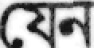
যেন
